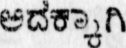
ಅದಕ್ಕಾಗಿ
